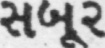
સબૂર
